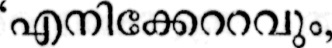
'എനിക്കേററവും,
